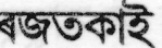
ৰজতকাই
